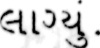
લાગ્યું.
